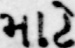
માટે
